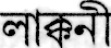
লাক্কনী
